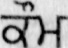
ਕੌਮ
